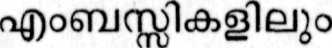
എംബസ്സികളിലും
